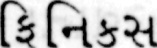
ફિનિક્સ
